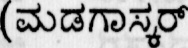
(ಮಡಗಾಸ್ಕರ್
